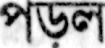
পড়ল
